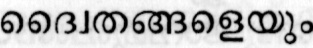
ദ്വൈതങ്ങളെയും
